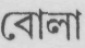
বোলা
